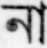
না
